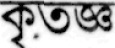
কৃতজ্ঞ
